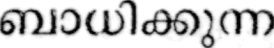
ബാധിക്കുന്ന
